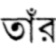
তাঁর
